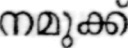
നമുക്ക്
